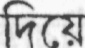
দিয়ে
